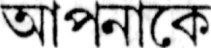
আপনাকে
